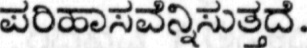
ಪರಿಹಾಸವೆನ್ನಿಸುತ್ತದೆ.
